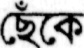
ছেঁকে
